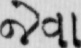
જેવા
